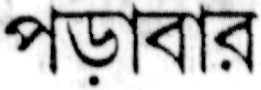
পড়াবার
